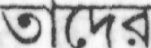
তাদের
